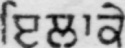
ਇਲਾਕੇ
